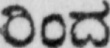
ರಿಂದ
